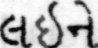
લઈને
